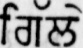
ਗਿੱਲੇ
